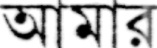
আমার
